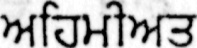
ਅਹਿਮੀਅਤ
